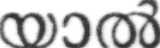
യാല്‍
